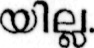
യില്ല.
